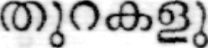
തുറകളു
